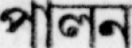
পালন
